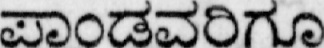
ಪಾಂಡವರಿಗೂ
